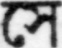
সে
